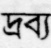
দ্রব্য
